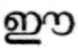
ഈ
